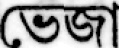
ভেজা
